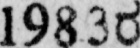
1983ರ
